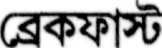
ব্রেকফাস্ট
